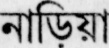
নাড়িয়া
